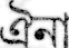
ঐনা
